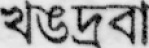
খঙদ্রবা
